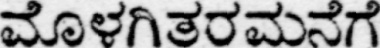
ಮೊಳಗಿತರಮನೆಗೆ
